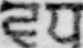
ਵਧ
